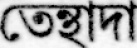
তেন্থাদা
